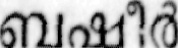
ബഷീര്‍
